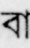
বা
